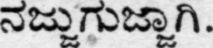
ನಜ್ಜುಗುಜ್ಜಾಗಿ.
